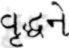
વૃદ્ધને
